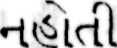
નહોતી
